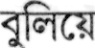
বুলিয়ে
